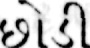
છોડી
